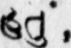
હતું,
